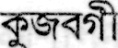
কুজবগী
